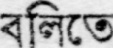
বলিতে
